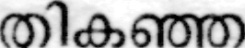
തികഞ്ഞ
